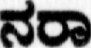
ನರಾ
